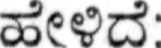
ಹೇಳಿದೆ:
